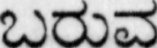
ಬರುವ
